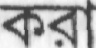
করা
